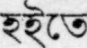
হইতে
